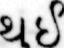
થઈ
